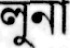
লুনা
